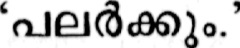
‘പലര്‍ക്കും.’
